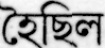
হৈছিল
